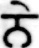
ਨੇ
